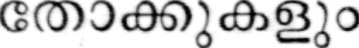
തോക്കുകളും
